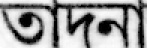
তাদনা
